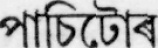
পাচিটোৰ
